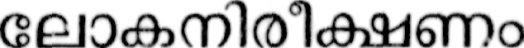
ലോകനിരീക്ഷണം
